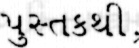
પુસ્તકથી,
